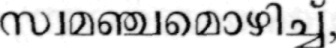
സ്വമഞ്ചമൊഴിച്ച്,
